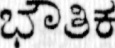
ಭೌತಿಕ
